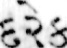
દરેક
